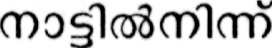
നാട്ടില്‍നിന്ന്
